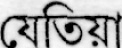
যেতিয়া
